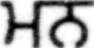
ਮਨ
